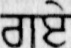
ਗਏ
